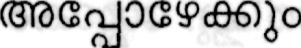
അപ്പോഴേക്കും
